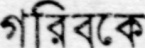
গরিবকে
